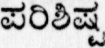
ಪರಿಶಿಷ್ಟ
